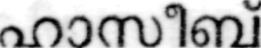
ഹാസീബ്
